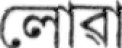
লোৱা
